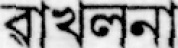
ৱাখলনা
